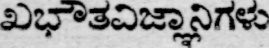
ಖಭೌತವಿಜ್ಞಾನಿಗಳು
